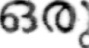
ഒരു
